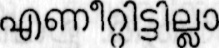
എണീറ്റിട്ടില്ലാ
